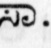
ಸಾ.
